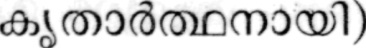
കൃതാര്‍ത്ഥനായി)
